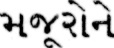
મજૂરોને
